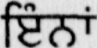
ਇੰਨਾਂ
